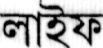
লাইফ
